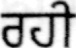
ਰਹੀ
